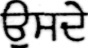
ਉਸਦੇ
